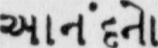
આનંદનો
